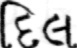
દિલ
